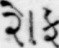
રોફ
